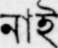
নাই
